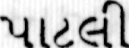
પાટલી
